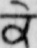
ਕੇ
